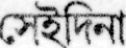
সেইদিনা
